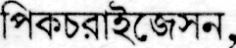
পিকচরাইজেসন,
